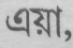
এয়া,
